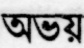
অভয়
